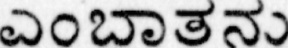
ಎಂಬಾತನು
